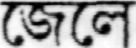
জেলে
